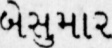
બેસુમાર
